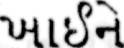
ખાઈને
